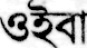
ওইবা
